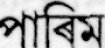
পাৰিম
